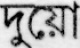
দুয়ো
